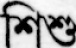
শিশু
